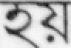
হয়
